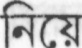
নিয়ে
